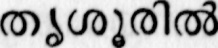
തൃശൂരില്‍
